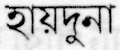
হায়দুনা
